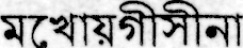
মখোয়গীসীনা
